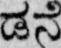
ಡನೆ
